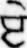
ਏ
